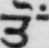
ਤੋਂ
